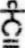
ਨੂੰ
